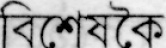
বিশেষকৈ
